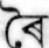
ৰৈ
